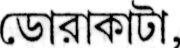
ডোরাকাটা,
